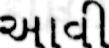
આવી
